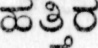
ಹತ್ತಿರ
